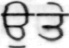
ਉਤੇ
